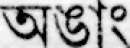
অঙাং
